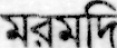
মরমদি
